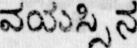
ವಯಸ್ಸಿನ
